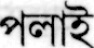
পলাই
